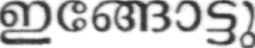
ഇങ്ങോട്ടു
